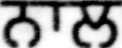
ਨਾਲ
